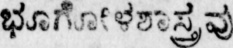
ಭೂಗೋಳಶಾಸ್ತ್ರವು
